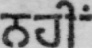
ਨਹੀਂ
